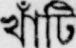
খাঁটি
